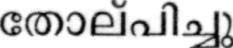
തോല്പിച്ചു
